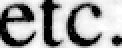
etc.
